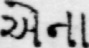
એના
